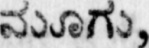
ಮೂಗು,
